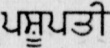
ਪਸ਼ੂਪਤੀ
